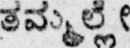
ತಮ್ಮಲ್ಲೇ
